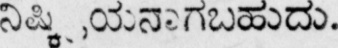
ನಿಷ್ಕ್ರಿಯನಾಗಬಹುದು.
